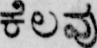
ಕೆಲವು
